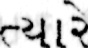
ત્યારે
